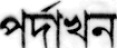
পর্দাখন
